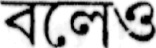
বলেও
